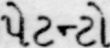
પેટન્ટો
